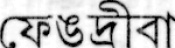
ফেঙদ্রীবা
